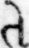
તે
